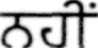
ਨਹੀਂ
